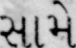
સામે
